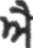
ਐ
